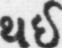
થઈ
